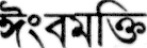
ঈংবমক্তি
